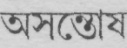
অসন্তোষ
